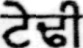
ਟੇਢੀ
